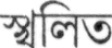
স্খলিত
